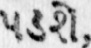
પડશે,
